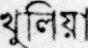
খুলিয়া
